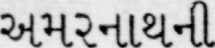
અમરનાથની
